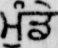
ਮੁੰਡੇ
